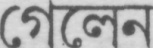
গেলেন
